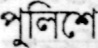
পুলিশে
